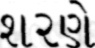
શરણે
